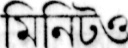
মিনিটও
